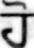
ਹੋ
